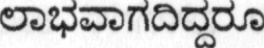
ಲಾಭವಾಗದಿದ್ದರೂ
